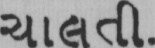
ચાલતી.
